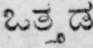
ಒತ್ತಡ
